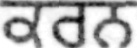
ਕਰਨ
